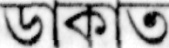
ডাকাত
